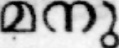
മനു
